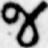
જ
